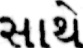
સાથે
